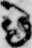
છે
